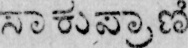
ಸಾಕುಪ್ರಾಣಿ
